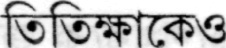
তিতিক্ষাকেও
